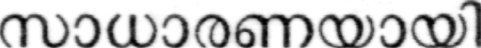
സാധാരണയായി
